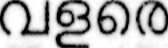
വളരെ
